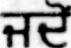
ਜਦੋਂ
